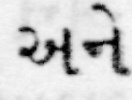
અને
